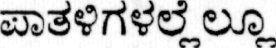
ಪಾತಳಿಗಳಲ್ಲೆಲ್ಲೂ
